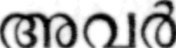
അവര്‍
